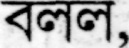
বলল,
